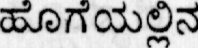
ಹೊಗೆಯಲ್ಲಿನ
